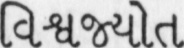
વિશ્વજ્યોત
